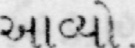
આવ્યો.
